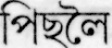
পিছলৈ
